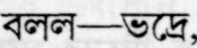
বলল–ভদ্রে,
